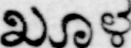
ಖೂಳ
